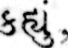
કહ્યું,
